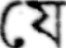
যে
